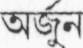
অর্জুন
